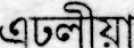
এঢলীয়া
